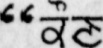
''ਕੌਣ
